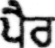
ਪੈਰ
